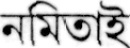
নমিতাই
